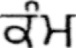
ਕੰਮ
